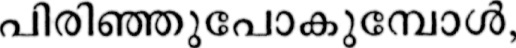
പിരിഞ്ഞുപോകുമ്പോള്‍,
